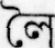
লৈ
